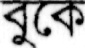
বুকে
